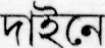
দাইনে
